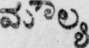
ಮೌಲ್ಯ
